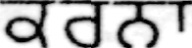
ਕਰਨਾ
